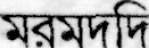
মরমদদি
